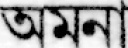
অমনা
